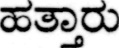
ಹತ್ತಾರು
